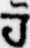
ਹੋ
